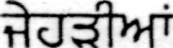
ਜੇਹੜੀਆਂ
